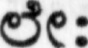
ಲೇ:
